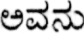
ಅವನು
